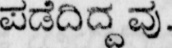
ಪಡೆದಿದ್ದವು.
